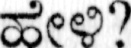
ಹೇಳಿ?
